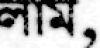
লাম,
